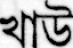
খাউ
